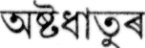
অষ্টধাতুৰ
